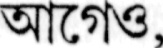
আগেও,
